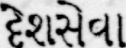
દેશસેવા
